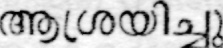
ആശ്രയിച്ചു
